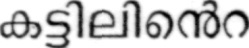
കട്ടിലിന്റെ
